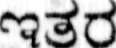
ಇತರ
